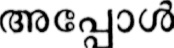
അപ്പോള്‍
